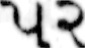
પર
